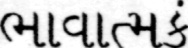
ભાવાત્મકં
